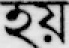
হয়
